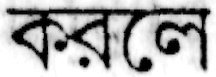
করলে
